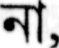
না,
